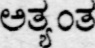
ಅತ್ಯಂತ
